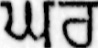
ਘਰ
